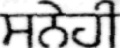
ਸਨੇਹੀ
